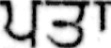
ਪਤਾ
